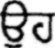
ਉਹ
